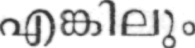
എങ്കിലും
